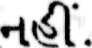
નહીં.
